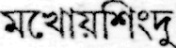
মখোয়শিংদু
